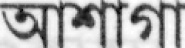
আশাগা
